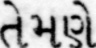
તેમણે
